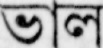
ভাল
